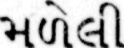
મળેલી
